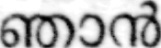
ഞാന്‍
